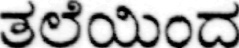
ತಲೆಯಿಂದ
